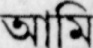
আমি
